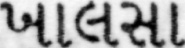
ખાલસા
